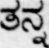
ತನ್ನ
